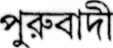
পুরুবাদী
